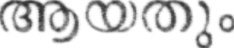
ആയതും
